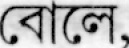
বোলে,
